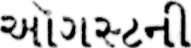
ઑગસ્ટની
